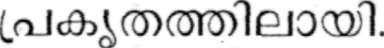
പ്രകൃതത്തിലായി.
